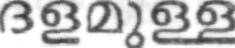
ദളമുള്ള
